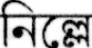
নিল্লে
